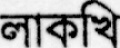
লাকখি
